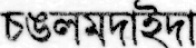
চঙলমদাইদা
